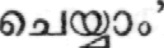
ചെയ്യാം’
